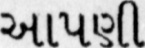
આપણી
